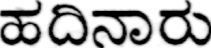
ಹದಿನಾರು
